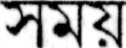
সময়
